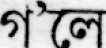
গ'লে
